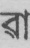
ৱা
